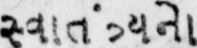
સ્વાતંત્ર્યનો
